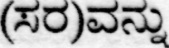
(ಸರ)ವನ್ನು
